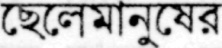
ছেলেমানুষের
